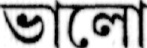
ভালো
